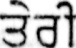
ਤੇਰੀ
